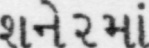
શનેરમાં
